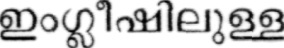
ഇംഗ്ലീഷിലുള്ള
